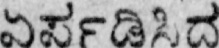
ಏರ್ಪಡಿಸಿದ
